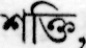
শক্তি,
